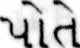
પોતે
